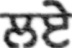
ਲਏ
